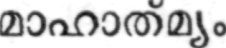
മാഹാത്മ്യം
